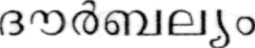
ദൌര്‍ബല്യം
